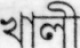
খালী
